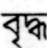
বৃদ্ধ
